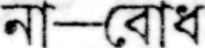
না—বোধ
